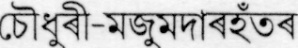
চৌধুৰী-মজুমদাৰহঁতৰ
